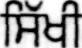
ਸਿੱਖੀ
